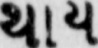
થાય
